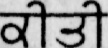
ਕੀਤੀ
